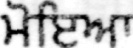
ਮੋਇਆ
